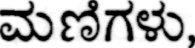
ಮಣಿಗಳು,
